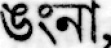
ঙংনা,
